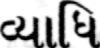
વ્યાધિ
